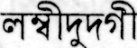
লম্বীদুদগী
